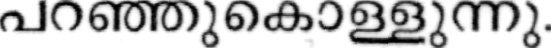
പറഞ്ഞുകൊള്ളുന്നു.
